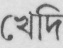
খেদি
